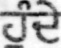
ਹੁੰਦੇ
